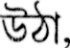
উঠা,
